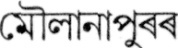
মৌলানাপুৰৰ
